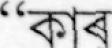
"কাৰ
